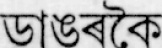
ডাঙৰকৈ
